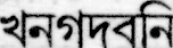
খনগদবনি
